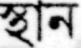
স্থান
